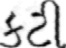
કટી
